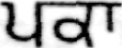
ਪਕਾ
